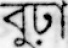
বুঢ়া
